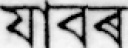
যাবৰ
